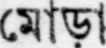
মোড়া
